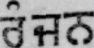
ਰੰਜਨ
